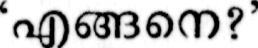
‘എങ്ങനെ?’
